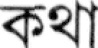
কথা
